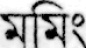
মমিং
